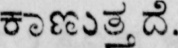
ಕಾಣುತ್ತದೆ.
